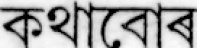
কথাবোৰ
